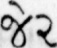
જેર
